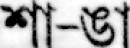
শা-ঙা
